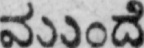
ಮುಂದೆ
